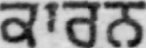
ਕਾਰਨ
